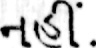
નહીં.
